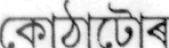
কোঠাটোৰ
